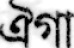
ঐগা
